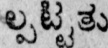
ಲ್ಪಟ್ಟಿತು
